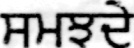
ਸਮਝਦੇ
